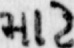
માટે
